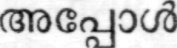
അപ്പോള്‍
